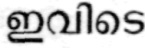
ഇവിടെ
